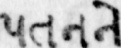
પતનને
